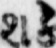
શકે
